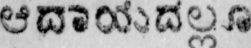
ಆದಾಯದಲ್ಲೂ
